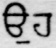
ਉਹ
